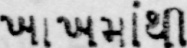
ખાખમાંથી
